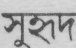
সুহৃদ
